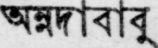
অন্নদাবাবু
